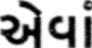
એવાં
